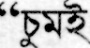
“চুমই
